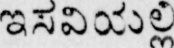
ಇಸವಿಯಲ್ಲಿ
